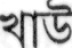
খাউ
